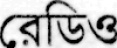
রেডিও
